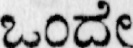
ಒಂದೇ
